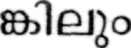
ങ്കിലും
